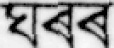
ঘৰৰ
